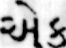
એક
